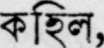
কহিল,
